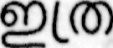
ഇത്ര
